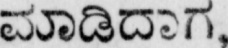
ಮಾಡಿದಾಗ,
